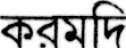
করমদি
